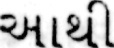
આથી
